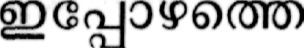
ഇപ്പോഴത്തെ
